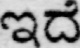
ಇದೆ
